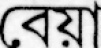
বেয়া
